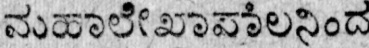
ಮಹಾಲೇಖಾಪಾಲನಿಂದ
